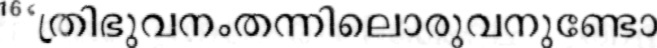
16'ത്രിഭുവനംതന്നിലൊരുവനുണ്ടോ
